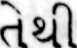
તેથી
